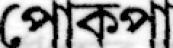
পোকপা
